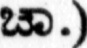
ಚಾ)
